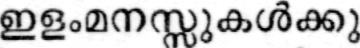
ഇളംമനസ്സുകള്‍ക്കു
